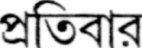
প্রতিবার
